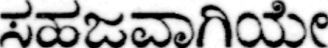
ಸಹಜವಾಗಿಯೇ
